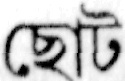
ছোট
